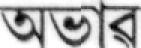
অভাৱ
